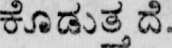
ಕೊಡುತ್ತದೆ.
